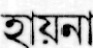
হায়না
